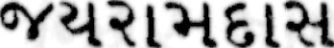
જયરામદાસ
